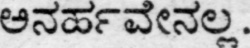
ಅನರ್ಹವೇನಲ್ಲ.
